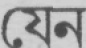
যেন
